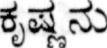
ಕೃಷ್ಣನು
